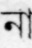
না
